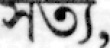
সত্য,
